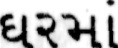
ઘરમાં
